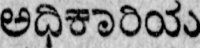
ಅಧಿಕಾರಿಯ
